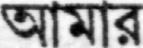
আমার
